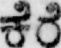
ಕೆರೆ
